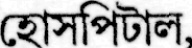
হোসপিটাল,
